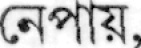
নেপায়,
